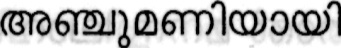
അഞ്ചുമണിയായി
